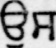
ਉਸ
